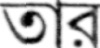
তার
